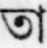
তা
